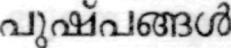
പുഷ്പങ്ങള്‍
